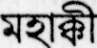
মহাক্কী
